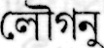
লৌগনু
